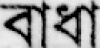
বাধা
